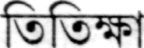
তিতিক্ষা
